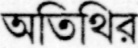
অতিথির
